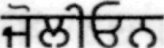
ਜੋਲੀਓਨ
